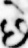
છે
